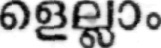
ളെല്ലാം
